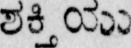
ಶಕ್ತಿಯು
